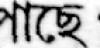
পাছে
